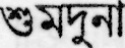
শুমদুনা
